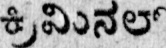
ಕ್ರಿಮಿನಲ್
